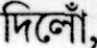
দিলোঁ,
